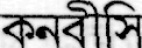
কনবীসি
